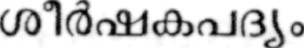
ശീര്‍ഷകപദ്യം
